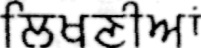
ਲਿਖਣੀਆਂ
